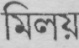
মিলয়
